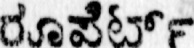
ರೂಪೆರ್ಟ್
